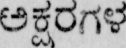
ಅಕ್ಷರಗಳ
